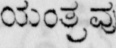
ಯಂತ್ರವು
